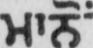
ਮਾਨੋਂ
